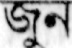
জুন
